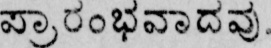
ಪ್ರಾರಂಭವಾದವು.
